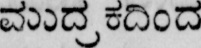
ಮುದ್ರಕದಿಂದ
